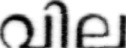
വില
